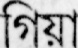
গিয়া
